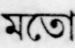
মতো
